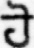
ਹੋ
